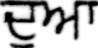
ਦੁਆ
